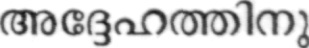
അദ്ദേഹത്തിനു
